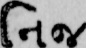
નિજ
